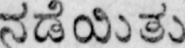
ನಡೆಯಿತು
